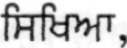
ਸਿਖਿਆ,
